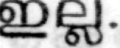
ഇല്ല.
